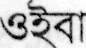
ওইবা
